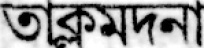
তাক্লমদনা
